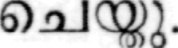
ചെയ്തു.
